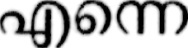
എന്നെ
